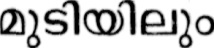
മുടിയിലും
